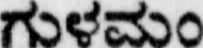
ಗುಳಮಂ
